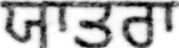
ਯਾਤਰਾ
